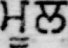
ਮੂਲ
